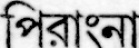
পিরাংনা
